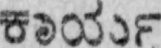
ಕಾರ್ಯ
